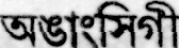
অঙাংসিগী
